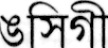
ঙসিগী
